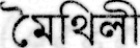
মৈথিলী
